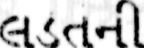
લડતની
